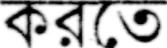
করতে
